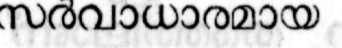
സര്‍വാധാരമായ
